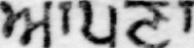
ਆਪਣਾ
